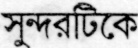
সুন্দরটিকে
